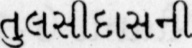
તુલસીદાસની
